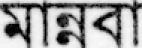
মান্নবা
